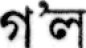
গ'ল
